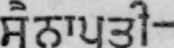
ਸੈਨਾਪਤੀ-
